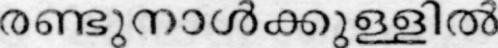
രണ്ടുനാള്‍ക്കുള്ളില്‍
